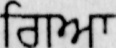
ਗਿਆ
